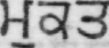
ਮੁਕਤ
